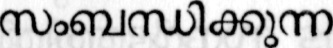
സംബന്ധിക്കുന്ന
